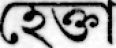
হেক্তা
